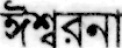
ঈশ্বরনা
